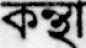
কন্থা
